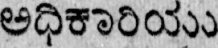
ಅಧಿಕಾರಿಯು
